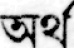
অর্থ
